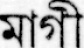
মাগী
